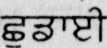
ਛੁਡਾਈ
